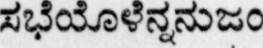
ಸಭೆಯೊಳೆನ್ನನುಜಂ
